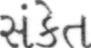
સંકેત
